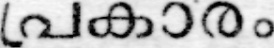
പ്രകാരം
